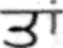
ਤਾਂ
